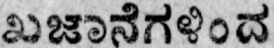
ಖಜಾನೆಗಳಿಂದ
